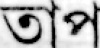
তাপ
